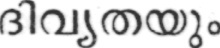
ദിവ്യതയും
